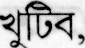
খুটিব,
